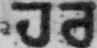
ਹਰ
